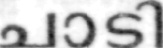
ചാടി
